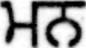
ਮਨ
